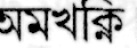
অমখক্নি
